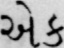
એક
